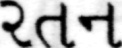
રતન
